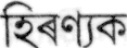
হিৰণ্যক
